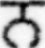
ਨ
